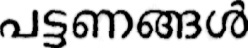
പട്ടണങ്ങള്‍
